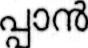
പ്പാന്‍
